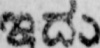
ಇದು
